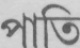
পাতি
